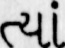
ત્યાં
